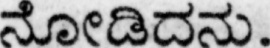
ನೋಡಿದನು.
